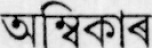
অম্বিকাৰ
